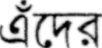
এঁদের
